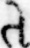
તે
